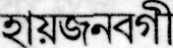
হায়জনবগী
